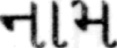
નામ
